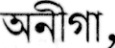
অনীগা,
